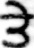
ਤੇ
